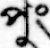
পুং
